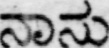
ನಾನು
